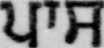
ਪਾਸ
